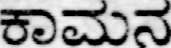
ಕಾಮನ
